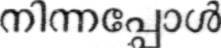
നിന്നപ്പോള്‍
